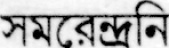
সমরেন্দ্রনি
